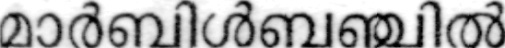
മാര്‍ബിള്‍ബഞ്ചില്‍
